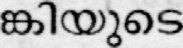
ങ്കിയുടെ
